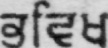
ਭਵਿਖ
